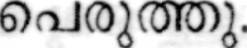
പെരുത്തു.
